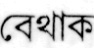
বেথাক
